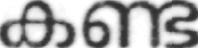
കണ്ട
